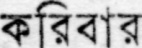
করিবার
